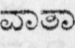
ವಾತಾ
